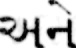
અને
